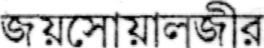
জয়সোয়ালজীর
